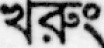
খরুং
